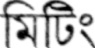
মিটিং
